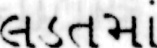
લડતમાં
